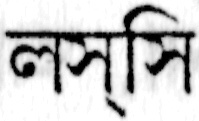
লস্‌সি
